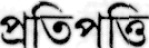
প্রতিপত্তি
